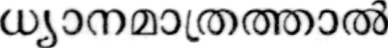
ധ്യാനമാത്രത്താല്‍
